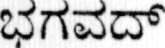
ಭಗವದ್
